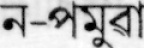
ন-পমুৱা
